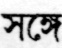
সঙ্গে
